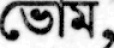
ভোম,
